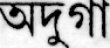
অদুগা
